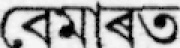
বেমাৰত
